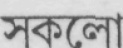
সকলো
